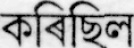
কৰিছিল
